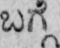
ಬಗ್ಗೆ
